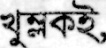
খুম্লকই,
